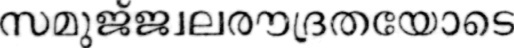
സമുജ്ജ്വലരൌദ്രതയോടെ
